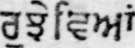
ਰੁਝੇਵਿਆਂ
